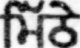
ਮਿੱਠੇ
